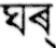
ঘৰ্
